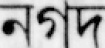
নগদ
